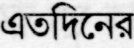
এতদিনের
